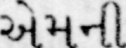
એમની
